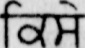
ਕਿਸੇ
